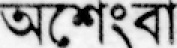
অশেংবা
